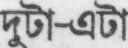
দুটা-এটা
